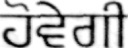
ਹੋਵੇਗੀ
